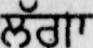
ਲੱਗਾ
